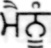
ਮੈਨੂੰ
